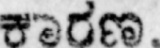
ಕಾರಣ.
